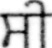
ਸੀ
